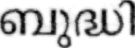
ബുദ്ധി
